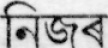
নিজৰ
